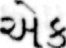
એક
